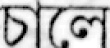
চালে
